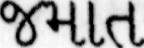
જમાત
